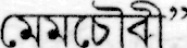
মেমচৌবী”
